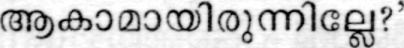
ആകാമായിരുന്നില്ലേ?’
